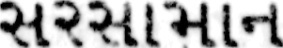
સરસામાન
